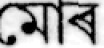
মোৰ
